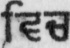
ਵਿਚ
